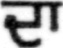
ਦਾ
